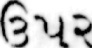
ઉપર
